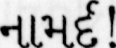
નામર્દ!
